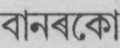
বানৰকো
